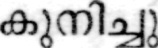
കുനിച്ചു
